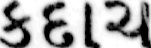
કદાચ
